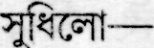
সুধিলো-
